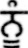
ਨੂੰ
